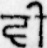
ਵੀ
